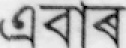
এবাৰ
